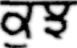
ਕੁਝ
